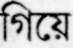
গিয়ে
